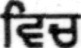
ਵਿਚ
